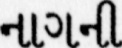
નાગની
